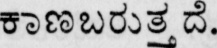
ಕಾಣಬರುತ್ತದೆ.
